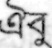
ঐবু
